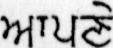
ਆਪਣੇ
